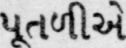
પૂતળીએ
